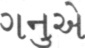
ગનુએ
